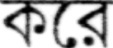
করে
